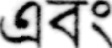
এবং
